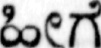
ಹೀಗೆ
